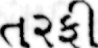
તરફી
